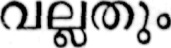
വല്ലതും
